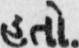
હતો.
